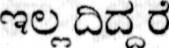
ಇಲ್ಲದಿದ್ದರೆ
